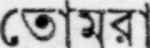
তোমরা
